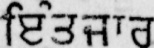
ਇੰਤਜਾਰ
